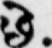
છે.
